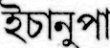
ইচানুপা
